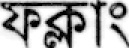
ফক্লাং
